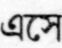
এসে
